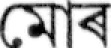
মোৰ
